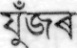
যুঁজৰ
